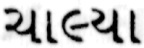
ચાલ્યા
